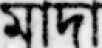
মাদা
